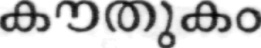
കൌതുകം
